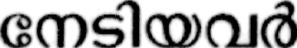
നേടിയവര്‍
